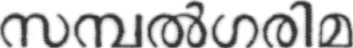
സമ്പല്‍ഗരിമ
